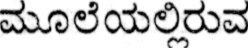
ಮೂಲೆಯಲ್ಲಿರುವ
